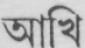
আখি
